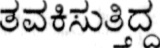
ತವಕಿಸುತ್ತಿದ್ದ
